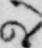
જે
